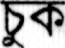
চুক
